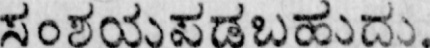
ಸಂಶಯಪಡಬಹುದು.
